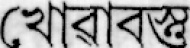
খোৱাবস্তু
